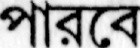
পারবে
